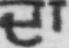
ਦਾ
